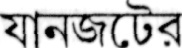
যানজটের
